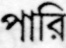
পারি
